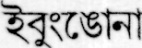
ইবুংঙোনা
